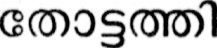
തോട്ടത്തി
